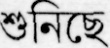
শুনিছে
